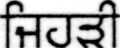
ਜਿਹੜੀ
